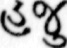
હજુ
